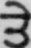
ਤੇ
